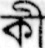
কী
